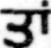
ਤਾਂ
